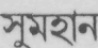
সুমহান
